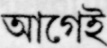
আগেই
